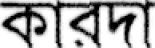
কারদা
